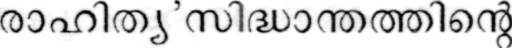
രാഹിത്യ'സിദ്ധാന്തത്തിന്റെ
